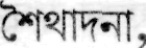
শৈথাদনা,
